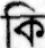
কি
